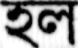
হল
